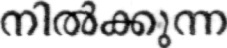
നില്‍ക്കുന്ന
